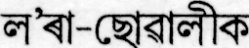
ল'ৰা-ছোৱালীক
